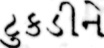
ટુકડીને
